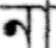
না
